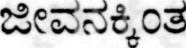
ಜೀವನಕ್ಕಿಂತ
